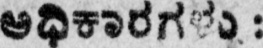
ಅಧಿಕಾರಗಳು:
